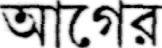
আগের
